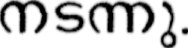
നടന്നു.
